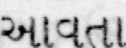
આવતા
